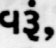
વરૂં,
